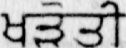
ਖੜੋਤੀ
